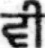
ਵੀ
